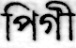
পিগী
